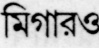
মিগারও
